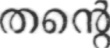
തന്റെ
